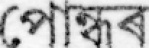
পোন্ধৰ
